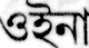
ওইনা
